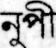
নুপী
